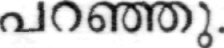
പറഞ്ഞു.
